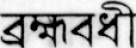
ব্রহ্মবধী
